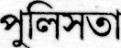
পুলিসতা
